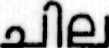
ചില
